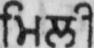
ਮਿਲੀ
